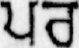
ਪਰ
